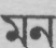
মন
